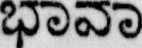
ಭಾವಾ
